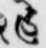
રહે
